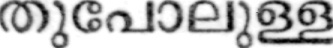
തുപോലുള്ള
